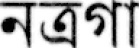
নত্রগা
